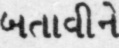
બતાવીને
